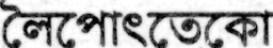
লৈপোৎতেকো
